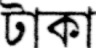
টাকা
